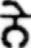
ਨੇ
